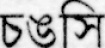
চঙসি
